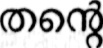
തന്റെ
